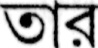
তার
